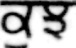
ਕੁਝ
